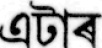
এটাৰ
